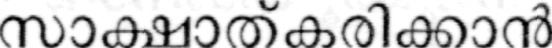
സാക്ഷാത്കരിക്കാന്‍
